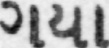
ગયા
